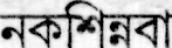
নকশিন্নবা
